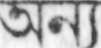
অন্য
